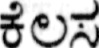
ಕೆಲಸ
